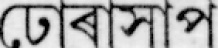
ঢোৰাসাপ
